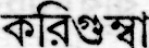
করিগুম্বা
